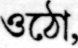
ওঠো,
